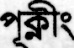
পূক্নীং
